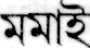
মমাই
